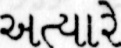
અત્યારે
